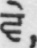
ਵੇ,
